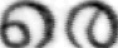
രെ
